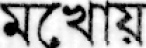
মখোয়
